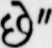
છે"
